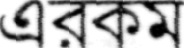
এরকম
